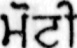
ਮੋਟੀ
